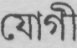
যোগী
